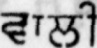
ਵਾਲੀ
